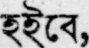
হইবে,
